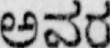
ಅವರ
